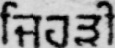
ਜਿਹੜੀ
